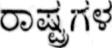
ರಾಷ್ಟ್ರಗಳ
